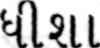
ઘીશા
